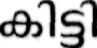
കിട്ടി
